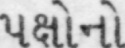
પક્ષોનો
